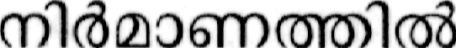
നിര്‍മാണത്തില്‍
